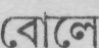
বোলে
